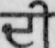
ਦੀ
